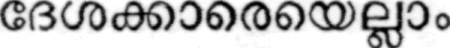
ദേശക്കാരെയെല്ലാം
